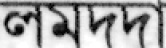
লমদদা
